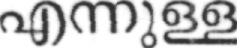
എന്നുള്ള
